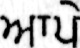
ਆਪੇ
